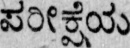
ಪರೀಕ್ಷೆಯ
